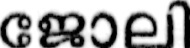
ജോലി
